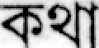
কথা
